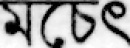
মচেৎ
